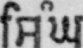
ਸਿੰਘ
